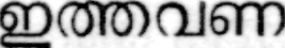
ഇത്തവണ
